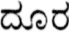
ದೂರ
